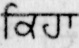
ਕਿਹਾ
